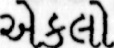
એકલો
